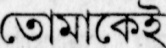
তোমাকেই
